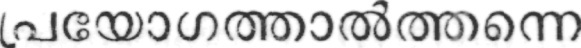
പ്രയോഗത്താല്‍ത്തന്നെ
